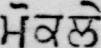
ਮੋਕਲੇ
